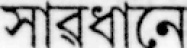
সাৱধানে
